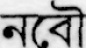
নবৌ
